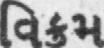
વિક્રમ
